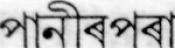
পানীৰপৰা
